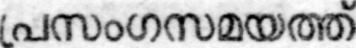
പ്രസംഗസമയത്ത്
